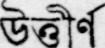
উত্তীর্ণ
